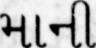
માની
